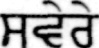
ਸਵੇਰੇ
